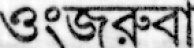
ওংজরুবা
